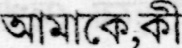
আমাকে,কী
